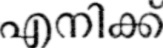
എനിക്ക്
